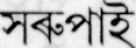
সৰুপাই
